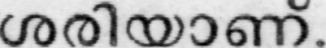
ശരിയാണ്.
